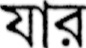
যার
